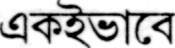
একইভাবে
